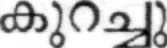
കുറച്ചു
